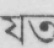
যত
